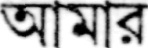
আমার
